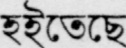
হইতেছে
